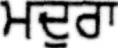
ਮਦੁਰਾ
